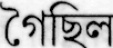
গৈছিল
